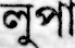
লুপা
